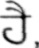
ਹੈ,
